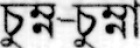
চুম্ন-চুম্না
